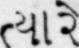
ત્યારે
